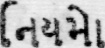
નિયમો
